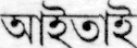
আইতাই
